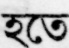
হতে
